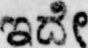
ಇದೇ
